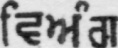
ਵਿਅੰਗ
